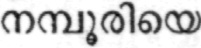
നമ്പൂരിയെ
